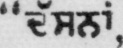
''ਦੱਸਨਾਂ,
